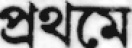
প্রথমে
